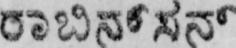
ರಾಬನ್‌ಸನ್
